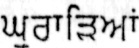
ਘੁਰਾੜਿਆਂ
